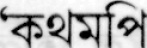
'কথমপি
